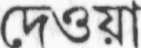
দেওয়া
